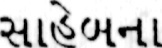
સાહેબના
